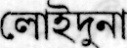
লোইদুনা
